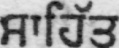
ਸਾਹਿੱਤ
